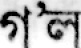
গ'ল
